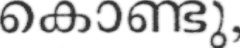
കൊണ്ടു,
